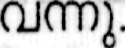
വന്നു.
